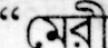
“মেরী
